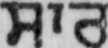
ਸਾਰ
